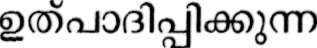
ഉത്പാദിപ്പിക്കുന്ന
